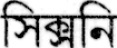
সিক্সনি
